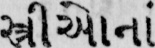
સ્ત્રીઓનાં
